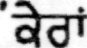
'ਕੇਰਾਂ
